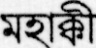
মহাক্কী
